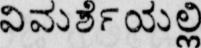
ವಿಮರ್ಶೆಯಲ್ಲಿ
